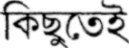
কিছুতেই
